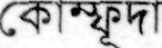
কোম্ফূদা
